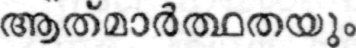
ആത്മാര്‍ത്ഥതയും
